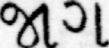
જાગ
